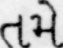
તમે
